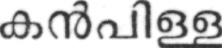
കന്‍പിള്ള
